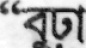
"বুঢ়া
